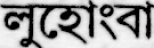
লুহোংবা
